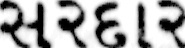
સરદાર
